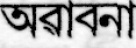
অৱাবনা
